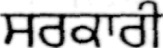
ਸਰਕਾਰੀ
